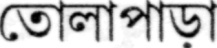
তোলাপাড়া
